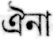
ঐনা
